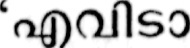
‘എവിടാ
